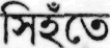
সিহঁতে
